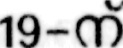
19-ന്
